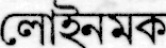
লোইনমক
